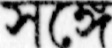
সঙ্গে
